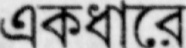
একধারে
